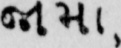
જામા
